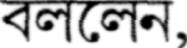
বললেন,
